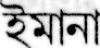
ইমানা
